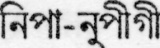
নিপা-নুপীগী
